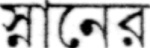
স্নানের
